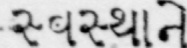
સ્વસ્થાને
